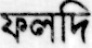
ফলদি
